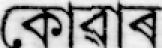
কোৱাৰ
